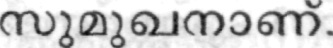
സുമുഖനാണ്.
